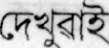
দেখুৱাই
